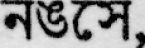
নঙসে,
